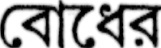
বোধের
